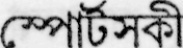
স্পোর্টসকী
